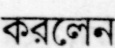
করলেন
